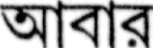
আবার
